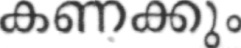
കണക്കും
